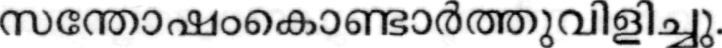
സന്തോഷംകൊണ്ടാര്‍ത്തുവിളിച്ചു.
